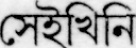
সেইখিনি
